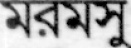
মরমসু
